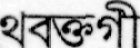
থবক্তগী
